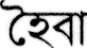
হৈবা
